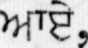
ਆਏ,
